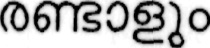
രണ്ടാളും
